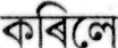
কৰিলে
